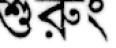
শুরুং
